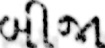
બીજા
